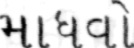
માધવો
